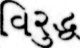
વિરુદ્ધ
